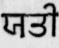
ਯਤੀ
